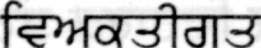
ਵਿਅਕਤੀਗਤ
